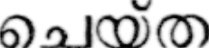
ചെയ്ത
